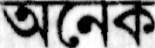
অনেক
